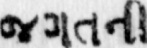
જગતની
